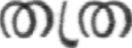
തത്ര
